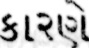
કારણે
